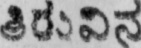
ತಿರುವಿನ
